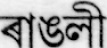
ৰাঙলী
